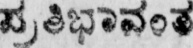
ಪ್ರತಿಭಾವಂತ
